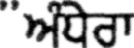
''ਅੰਧੇਰਾ
